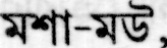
মশা-মউ,
